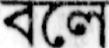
বলে
